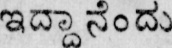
ಇದ್ದಾನೆಂದು
